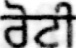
ਰੋਟੀ
